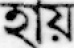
হায়
